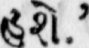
હશે.'
